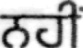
ਨਹੀਂ
